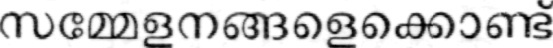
സമ്മേളനങ്ങളെക്കൊണ്ട്
